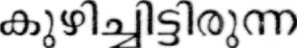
കുഴിച്ചിട്ടിരുന്ന
